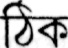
ঠিক
